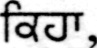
ਕਿਹਾ,
